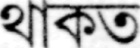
থাকত
